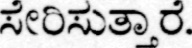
ಸೇರಿಸುತ್ತಾರೆ.
